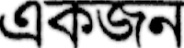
একজন
